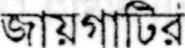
জায়গাটির
